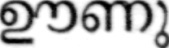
ഊണു
